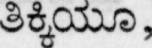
ತಿಕ್ಕಿಯೂ,
